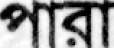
পারা
